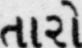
તારો
